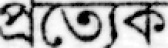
প্রত্যেক
